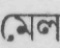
মেল
